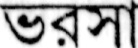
ভরসা
